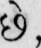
છે,
